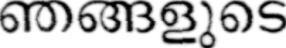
ഞങ്ങളുടെ
